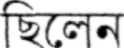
ছিলেন
